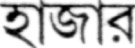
হাজার
